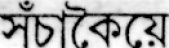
সঁচাকৈয়ে
